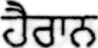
ਹੈਰਾਨ
